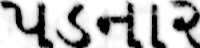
પડનાર
